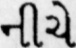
નીચે
